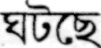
ঘটছে
